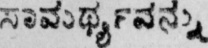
ಸಾಮರ್ಥ್ಯವನ್ನು
